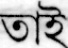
তাই
